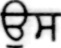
ਉਸ
